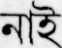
নাই
